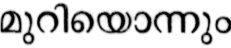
മുറിയൊന്നും
